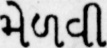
મેળવી
